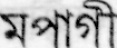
মপাগী
